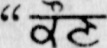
''ਕੌਣ
